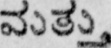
ಮತ್ತು
